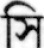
সি
